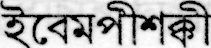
ইবেমপীশক্কী
